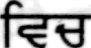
ਵਿਚ
